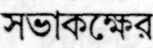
সভাকক্ষের
